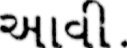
આવી.
